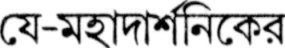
যে-মহাদার্শনিকের
